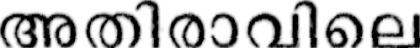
അതിരാവിലെ
